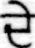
ਦੇ
